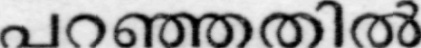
പറഞ്ഞതില്‍
